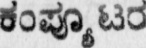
ಕಂಪ್ಯೂಟರ
